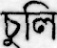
চুলি
